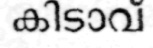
കിടാവ്
